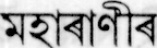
মহাৰাণীৰ
